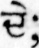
ਦੇ;
